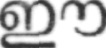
ഈ
